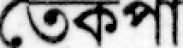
তেকপা
